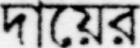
দায়ের
